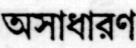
অসাধারণ
